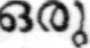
ഒരു
